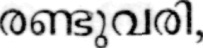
രണ്ടുവരി,
